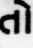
તો
